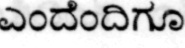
ಎಂದೆಂದಿಗೂ
